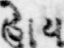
હોય
